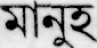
মানুহ
